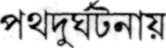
পথদুর্ঘটনায়
